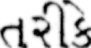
તરીકે
